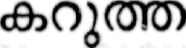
കറുത്ത
